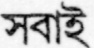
সবাই
